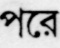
পরে
